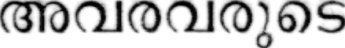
അവരവരുടെ
